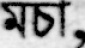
মচা,
